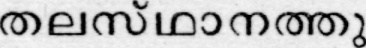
തലസ്ഥാനത്തു
